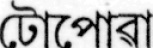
টোপোৱা
